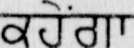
ਕਹੇਂਗਾ
